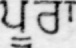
ਪੂਰਾ
